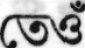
তেওঁ
